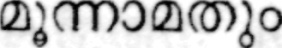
മൂന്നാമതും
